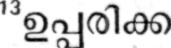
13ഉപ്പരിക്ക
